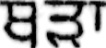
ਥੜਾ
